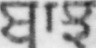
ਬਾਝ
